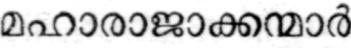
മഹാരാജാക്കന്മാര്‍
